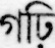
গঢ়ি
